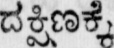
ದಕ್ಷಿಣಕ್ಕೆ
